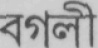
বগলী
